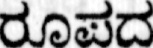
ರೂಪದ
